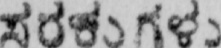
ಸರಕುಗಳು
